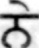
ਨੇ
